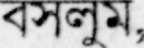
বসলুম,
